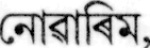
নোৱাৰিম,
